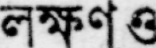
লক্ষণও
